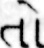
તો
